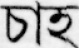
চাহ
